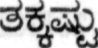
ತಕ್ಕಷ್ಟು
